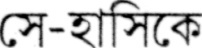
সে-হাসিকে
